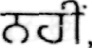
ਨਹੀਂ,
